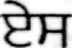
ਏਸ
